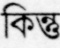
কিন্তু
